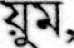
য়ুম,
